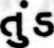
તુંડ
